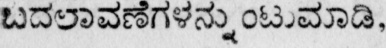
ಬದಲಾವಣೆಗಳನ್ನುಂಟುಮಾಡಿ,
